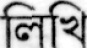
লিখি
